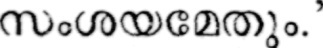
സംശയമേതും.'
